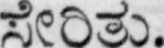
ಸೇರಿತು.
